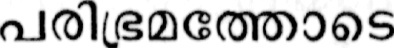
പരിഭ്രമത്തോടെ
